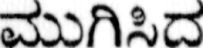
ಮುಗಿಸಿದ
